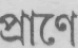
প্রাণে
